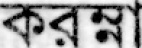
করম্না
